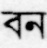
বন
